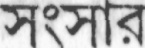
সংসার
